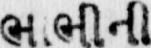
ભાભીની
